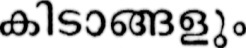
കിടാങ്ങളും
